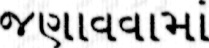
જણાવવામાં
